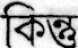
কিন্তু
